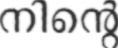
നിന്റെ
